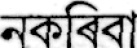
নকৰিবা
